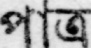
পাত্র
